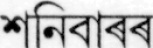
শনিবাৰৰ
